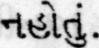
નહોતું.
